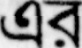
এর
